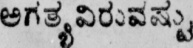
ಅಗತ್ಯವಿರುವಷ್ಟು
